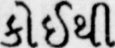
કોઈથી
